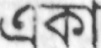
একা
